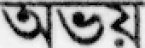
অভয়
